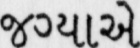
જગ્યાએ
